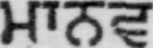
ਮਾਨਵ
